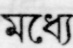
মধ্যে
